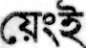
য়েংই
